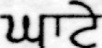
ਘਾਟੇ
